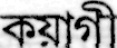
কয়াগী
